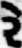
રે
